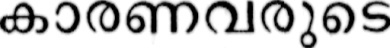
കാരണവരുടെ
